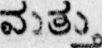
ಮತ್ತು
